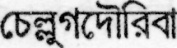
চেল্লুগদৌরিবা
